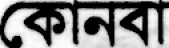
কোনবা
